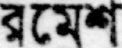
রমেশ
